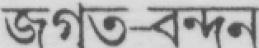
জগত-বন্দন
